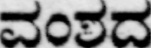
ವಂಶದ
